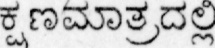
ಕ್ಷಣಮಾತ್ರದಲ್ಲಿ
